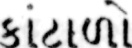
કાંટાળો
